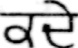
ਕਦੇ
